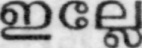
ഇല്ലേ
